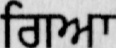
ਗਿਆ
